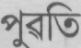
পুৱতি
